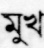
মুখ
